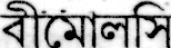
বীমোলসি
